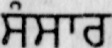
ਸੰਸਾਰ
